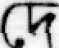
দে
